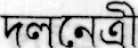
দলনেত্রী
